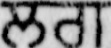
ਲਗ
